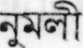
নুমলী
